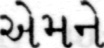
એમને
